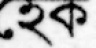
হেক
